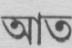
আত
